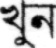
খুন
